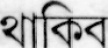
থাকিব
